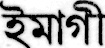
ইমাগী
